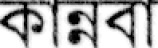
কান্নবা
